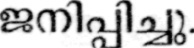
ജനിപ്പിച്ചു.
